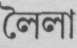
লৈলা
